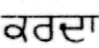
ਕਰਦਾ
